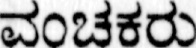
ವಂಚಕರು
